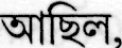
আছিল,
